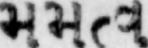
મમત્વ
